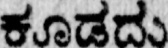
ಕೂಡದು
